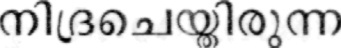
നിദ്രചെയ്തിരുന്ന
